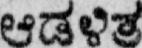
ಆಡಳಿತ
